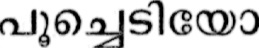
പൂച്ചെടിയോ
